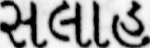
સલાહ
